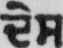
ਦੇਸ
